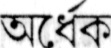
অর্ধেক
